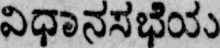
ವಿಧಾನಸಭೆಯ
